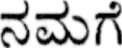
ನಮಗೆ
